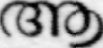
ആ
